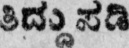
ತಿದ್ದುಪಡಿ
